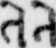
તેને
